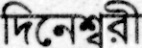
দিনেশ্বরী
